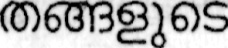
തങ്ങളുടെ
